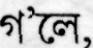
গ'লে,
